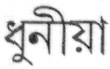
ধুনীয়া
